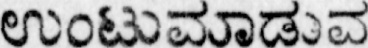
ಉಂಟುಮಾಡುವ
